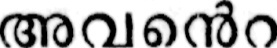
അവന്റെ
